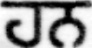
ਹਨ
